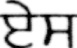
ਏਸ
